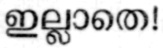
ഇല്ലാതെ!
